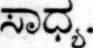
ಸಾಧ್ಯ.
